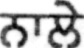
ਨਾਲੇ
